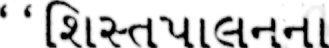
"શિસ્તપાલનના
